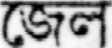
জেল
